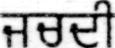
ਜਚਦੀ
